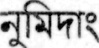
নুমিদাং
